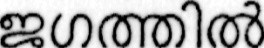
ജഗത്തില്‍
